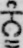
ਨੂੰ
